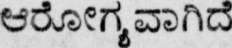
ಆರೋಗ್ಯವಾಗಿದೆ
